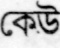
কেউ
